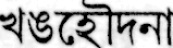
খঙহৌদনা
